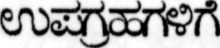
ಉಪಗ್ರಹಗಳಿಗೆ
